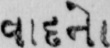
વાદનો
